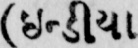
(ઇન્ડીયા
